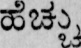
ಹೆಚ್ಚು
